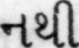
નથી
